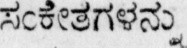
ಸಂಕೇತಗಳನ್ನು
